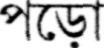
পড়ো
